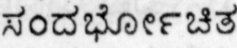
ಸಂದರ್ಭೋಚಿತ
